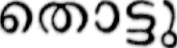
തൊട്ടു
